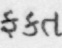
ફક્ત
